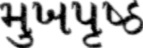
મુખપૃષ્ઠ
